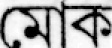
মোক
